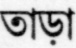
তাড়া
